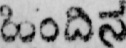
ಹಿಂದಿನ
